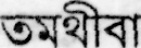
তমথীবা
